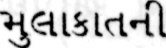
મુલાકાતની
